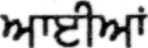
ਆਈਆਂ
